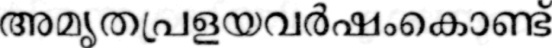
അമൃതപ്രളയവര്‍ഷംകൊണ്ട്
